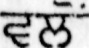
ਵਲੋਂ
